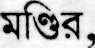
মণ্ডির,
